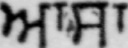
ਆਸਾ
